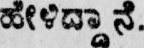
ಹೇಳಿದ್ದಾನೆ.
